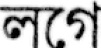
লগে
